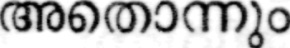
അതൊന്നും
